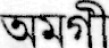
অমগী
